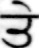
ਤੇ
